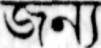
জন্য
